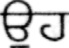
ਉਹ
